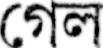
গেল
